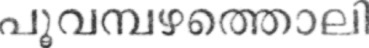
പൂവമ്പഴത്തൊലി
